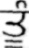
ਤੂੰ
